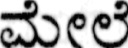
ಮೇಲೆ
